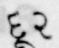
દૂર
